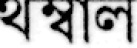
থম্বাল
